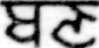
ਬਣ
